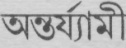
অন্তৰ্য্যামী
